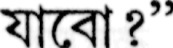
যাবো?"
